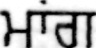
ਮਾਂਗ
